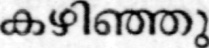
കഴിഞ്ഞു
